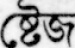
ষ্টেজ
